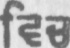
ਵਿਚ
